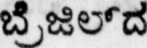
ಬ್ರೆಜಿಲ್ದ
